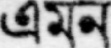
এমন
